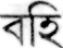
বহি
